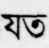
যত
